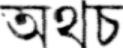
অথচ
